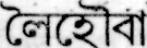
লৈহৌবা
